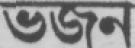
ভজন
